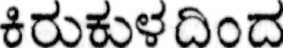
ಕಿರುಕುಳದಿಂದ
